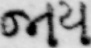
જાય
